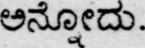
ಅನ್ನೋದು.
